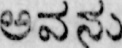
ಅವನು
